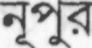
নূপুর
